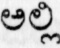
ಅಲ್ಲಿ
